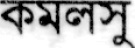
কমলসু
